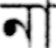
না
